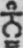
ਨੂੰ
